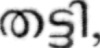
തട്ടി,
